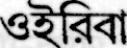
ওইরিবা
